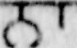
ਨਾ
